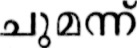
ചുമന്ന്
